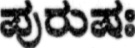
ಪುರುಷಃ
